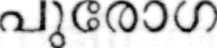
പുരോഗ
